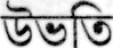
উভতি
